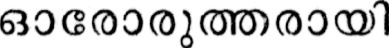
ഓരോരുത്തരായി
